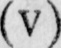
(v)
